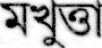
মখুত্তা
